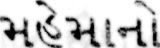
મહેમાનો
